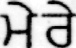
ਮੇਰੇ
